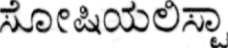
ಸೋಷಿಯಲಿಸ್ಟಾ
